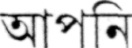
আপনি
